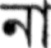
না
